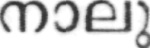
നാലു
